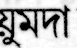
য়ুমদা
